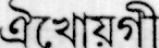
ঐখোয়গী
